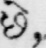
છે,
